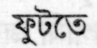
ফুটতে
